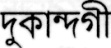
দুকান্দগী
